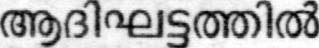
ആദിഘട്ടത്തില്‍
